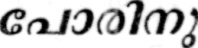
പോരിനു
